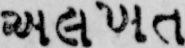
અલખત
